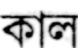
কাল
